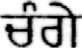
ਚੰਗੇ
